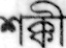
শক্কী
